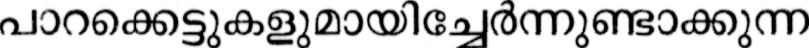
പാറക്കെട്ടുകളുമായിച്ചേര്‍ന്നുണ്ടാക്കുന്ന
